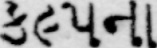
કલ્પવા
